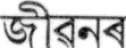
জীৱনৰ
